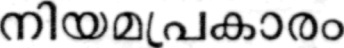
നിയമപ്രകാരം
